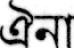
ঐনা
